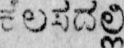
ಕೆಲಸದಲ್ಲಿ
